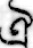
ঐ
